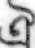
ঐ
